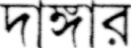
দাঙ্গার
